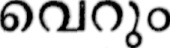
വെറും
